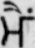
ਮੈਂ
